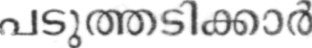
പടുത്തടിക്കാര്‍
